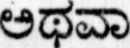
ಅಥವಾ
